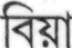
বিয়া
